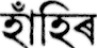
হাঁহিৰ
